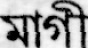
মাগী
